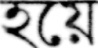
হয়ে
